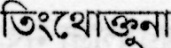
তিংথোক্তুনা
